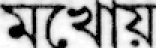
মখোয়
